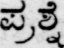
ಪ್ರಶ್ನೆ
